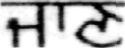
ਜਾਣ
